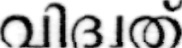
വിദ്വത്
